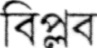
বিপ্লব
